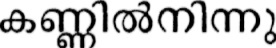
കണ്ണില്‍നിന്നു
